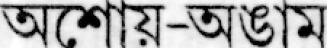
অশোয়-অঙাম
